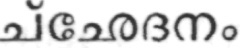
ച്ഛേദനം
